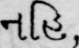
નહિ,
